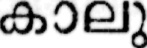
കാലു
